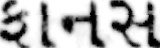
ફાનસ
